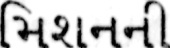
મિશનની
